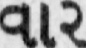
વાર
